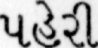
પહેરી
